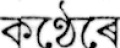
কণ্ঠেৰে
